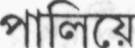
পালিয়ে
